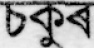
চকুৰ
